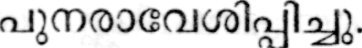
പുനരാവേശിപ്പിച്ചു.
